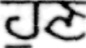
ਹੁਣ
